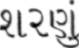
શરણું
